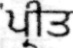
'ਪ੍ਰੀਤ
